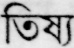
তিষ্য
